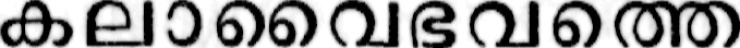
കലാവൈഭവത്തെ
